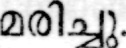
മരിച്ചു.
